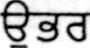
ਉਭਰ
